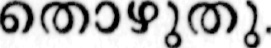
തൊഴുതു.
